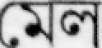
মেল
